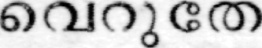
വെറുതേ
